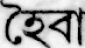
হৈবা
